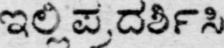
ಇಲ್ಲಿಪ್ರದರ್ಶಿಸಿ
